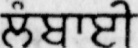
ਲੰਬਾਈ
